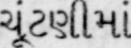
ચૂંટણીમાં
